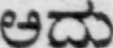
ಅದು
